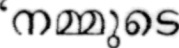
'നമ്മുടെ
